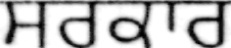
ਸਰਕਾਰ
